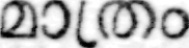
മാത്രം
